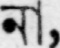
না,
